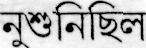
নুশুনিছিল
